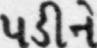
પડીને
